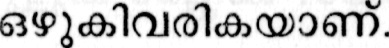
ഒഴുകിവരികയാണ്.
